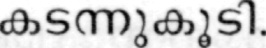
കടന്നുകൂടി.
